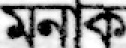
মনাক
